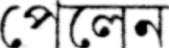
পেলেন
